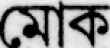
মোক
